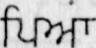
ਪਿਆ
